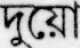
দুয়ো
